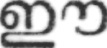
ഈ
